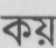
কয়
